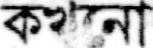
কখনো
